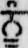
ਨੂੰ
